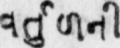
વર્તુળની
